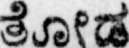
ತೋಡ
